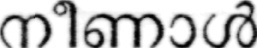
നീണാള്‍
